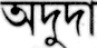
অদুদা
